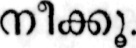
നീക്കൂ.
